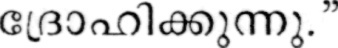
ദ്രോഹിക്കുന്നു.”
